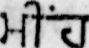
ਮੀਂਹ
